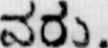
ವರು.
